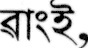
ৱাংই,
